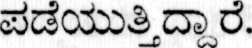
ಪಡೆಯುತ್ತಿದ್ದಾರೆ.
